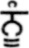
ਨੂੰ
